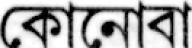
কোনোবা
